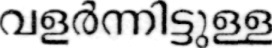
വളര്‍ന്നിട്ടുള്ള
